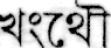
খংথৌ
